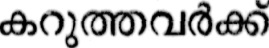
കറുത്തവര്‍ക്ക്
